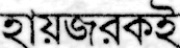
হায়জরকই
